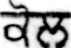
ਕੋਲ
